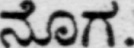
ನೊಗ.
